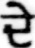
ਦੇ
